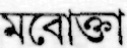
মবোক্তা
